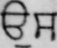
ਉਸ
